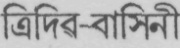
ত্ৰিদিৱ-বাসিনী
